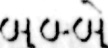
બબ્બે
